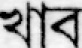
খাব
